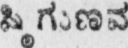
ಷ್ಠಿ ಗುಣವ
